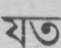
যত
